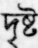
দৃষ্ট
